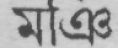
মঞি
